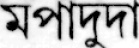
মপাদুদা
